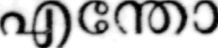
എന്തോ
